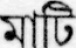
মাটি
